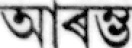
আৰম্ভ
